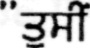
''ਤੁਸੀਂ
